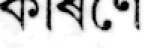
কাৰণে
